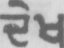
ਦੇਖ
